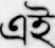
এই
